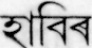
হাবিৰ
